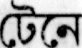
টেনে
